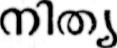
നിത്യ
